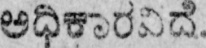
ಅಧಿಕಾರವಿದೆ.
